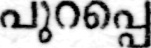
പുറപ്പെ
